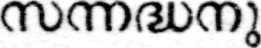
സന്നദ്ധനു
